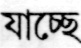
যাচ্ছে
